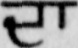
ਦਾ
